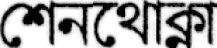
শেনথোক্না
